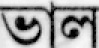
ভাল
